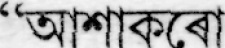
"আশাকৰো
